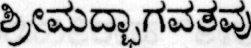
ಶ್ರೀಮದ್ಭಾಗವತವು
